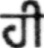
ਹੀ
